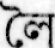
লৈ
